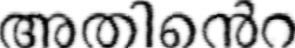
അതിന്റെ
